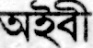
অইবী
